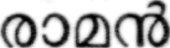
രാമന്‍
